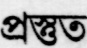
প্রস্তুত
